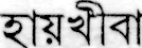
হায়খীবা
